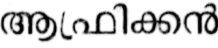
ആഫ്രിക്കന്‍
